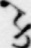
કે
